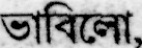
ভাবিলো,
